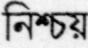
নিশ্চয়
